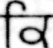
ਕਿ
